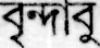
বৃন্দাবু
